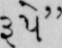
રૂપે”
